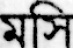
মসি
